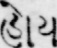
હોય
